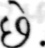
છે.
